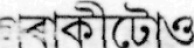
গৰাকীটোও
